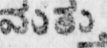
ಮತ್ತು
